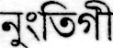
নুংতিগী
